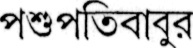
পশুপতিবাবুর
